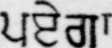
ਪਏਗਾ
